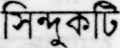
সিন্দুকটি
